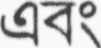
এবং
